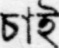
চাই
